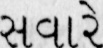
સવારે
